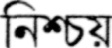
নিশ্চয়
